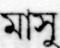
মাসু
